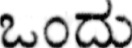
ಒಂದು
